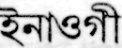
ইনাওগী
